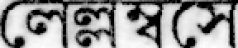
লেল্লম্বসে
